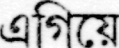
এগিয়ে
